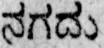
ನಗದು
